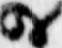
જ
